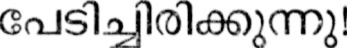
പേടിച്ചിരിക്കുന്നു!
